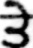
ਤੇ
